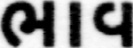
ભાવ
